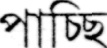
পাচ্ছি
